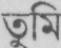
তুমি
